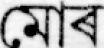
মোৰ
